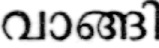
വാങ്ങി
